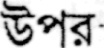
উপর
